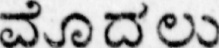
ಮೊದಲು
